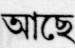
আছে
